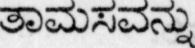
ತಾಮಸವನ್ನು
